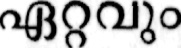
ഏറ്റവും
